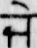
ਜੇ
